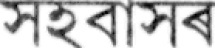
সহবাসৰ
